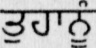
ਤੁਹਾਨੂੰ
